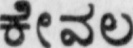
ಕೇವಲ
